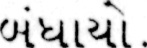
બંધાયો.
